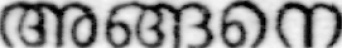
അങ്ങനെ
